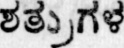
ಶತ್ರುಗಳ
